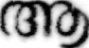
ആ
